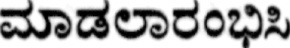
ಮಾಡಲಾರಂಭಿಸಿ
